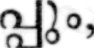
പ്പും,
